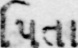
પિતા
